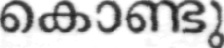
കൊണ്ടു
